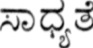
ಸಾಧ್ಯತೆ
